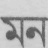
মন
